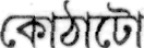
কোঠাটো
